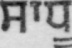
ਸਾਧੂ
